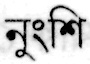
নুংশি
